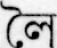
লৈ
